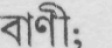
বাণী;
